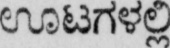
ಊಟಗಳಲ್ಲಿ
